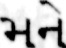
મને
